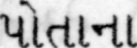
પોતાના
